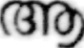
ആ
